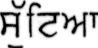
ਸੁੱਟਿਆ
